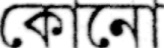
কোনো
